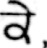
ਕੇ,
